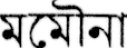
মমৌনা
